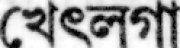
খেৎলগা
